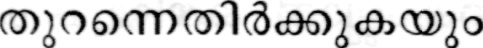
തുറന്നെതിര്‍ക്കുകയും
